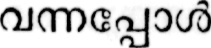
വന്നപ്പോള്‍
